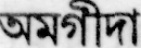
অমগীদা
